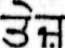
ਤੇਜ਼
